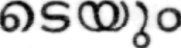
ടെയും
